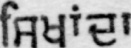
ਸਿਖਾਂਦਾ
